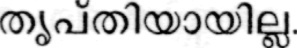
തൃപ്തിയായില്ല.
